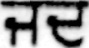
ਜਦ
